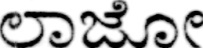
ಲಾಜೋ
